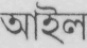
আইল
